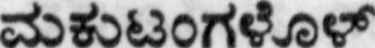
ಮಕುಟಂಗಳೊಳ್
